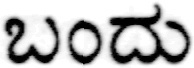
ಬಂದು
